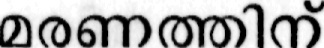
മരണത്തിന്
